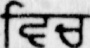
ਵਿਚ
